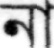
না
